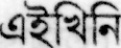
এইখিনি
